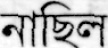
নাছিল
